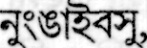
নুংঙাইবসু,
